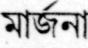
মার্জনা
